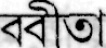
ববীতা
